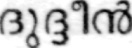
ദുദ്ദീന്‍
